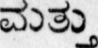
ಮತ್ತು
